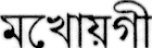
মখোয়গী
